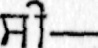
ਸੀ-
